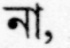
না,
